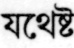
যথেষ্ট
